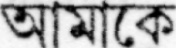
আমাকে
